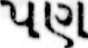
પણ
